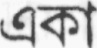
একা
